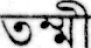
তম্মী
